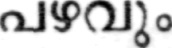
പഴവും
